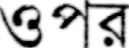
ওপর
